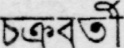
চক্রবর্তী
